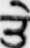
ਤੇ
